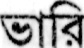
ভারি
